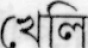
খেলি
